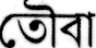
তৌবা
